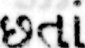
છતાં
